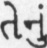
તેનું
